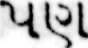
પણ
